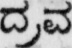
ದ್ರವ
